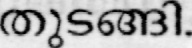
തുടങ്ങി.
